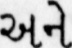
અને
